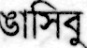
ঙাসিবু
